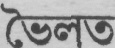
ভৈলত
